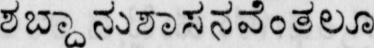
ಶಬ್ದಾನುಶಾಸನವೆಂತಲೂ
